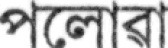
পলোৱা
